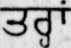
ਤਰ੍ਹਾਂ
